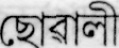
ছোৱালী
